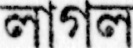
লাগল
